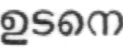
ഉടനെ
